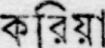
করিয়া
